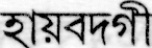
হায়বদগী
